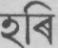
হৰি
